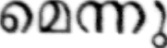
മെന്നു
